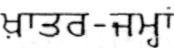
ਖ਼ਾਤਰ-ਜਮ੍ਹਾਂ
